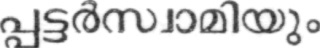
പ്പട്ടര്‍സ്വാമിയും
